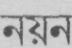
নয়ন
